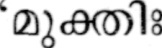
‘മുക്തിഃ
